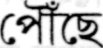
পৌঁছে
